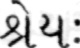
શ્રેયઃ
